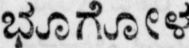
ಭೂಗೋಳ
